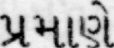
પ્રમાણે
